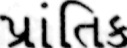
પ્રાંતિક
